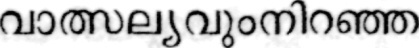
വാത്സല്യവുംനിറഞ്ഞ
